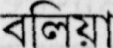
বলিয়া
